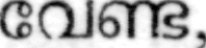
വേണ്ട,
